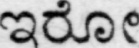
ಇರೋ
